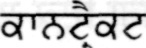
ਕਾਨਟ੍ਰੈਕਟ
